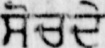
ਸੋਚਦੇ
